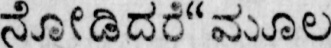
ನೋಡಿದರೆ“ಮೂಲ
